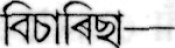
বিচাৰিছা-
